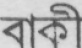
বাকী
